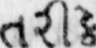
તરીકે
